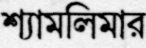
শ্যামলিমার
